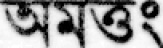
অমত্তং
